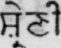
ਸ਼੍ਰੇਣੀ
